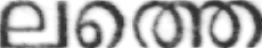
ലത്തെ
